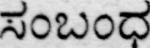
ಸಂಬಂಧ
